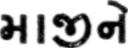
માજીને
